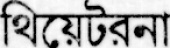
থিয়েটরনা
